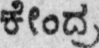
ಕೇಂದ್ರ
